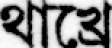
থাখ্রে
